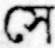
সে
